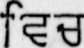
ਵਿਚ
